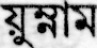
য়ুম্নাম
